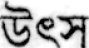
উৎস
